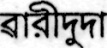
ৱারীদুদা
